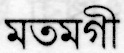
মতমগী
